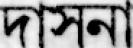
দাসনা
